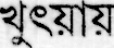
খুৎয়ায়
